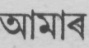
আমাৰ
